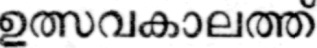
ഉത്സവകാലത്ത്
